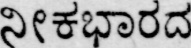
ನೀಕಭಾರದ
